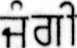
ਜੰਗੀ
